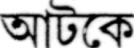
আটকে
